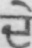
ਦੇ
